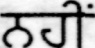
ਨਹੀਂ
